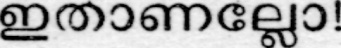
ഇതാണല്ലോ!
